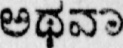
ಅಥವಾ
